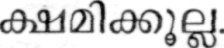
ക്ഷമിക്കൂല്ല.
